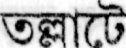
তল্লাটে
